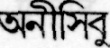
অনীসিবু
